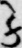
કે
